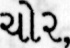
ચોર,
